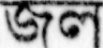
জল
